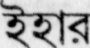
ইহার
